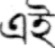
এই
